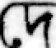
দে
